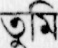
তুমি
